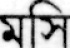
মসি
